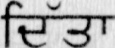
ਦਿੱਤਾ
